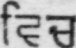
ਵਿਚ
